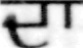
ਦਾ
